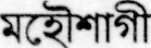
মহৌশাগী
